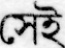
সেই
